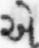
એ
